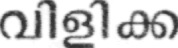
വിളിക്ക
